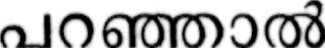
പറഞ്ഞാല്‍
